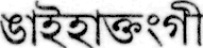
ঙাইহাক্তংগী
